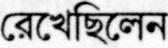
রেখেছিলেন
